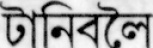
টানিবলৈ
